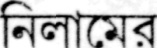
নিলামের
